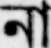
না
